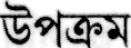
উপক্রম
